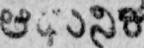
ಆಧುನಿಕ
